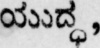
ಯುದ್ಧ,
